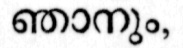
ഞാനും,
